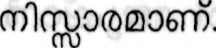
നിസ്സാരമാണ്.
